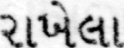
રાખેલા
